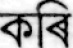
কৰি
